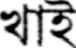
খাই
